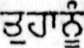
ਤੁਹਾਨੂੰ
